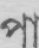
পা
